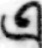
এ
